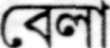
বেলা
